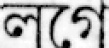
লগে
